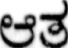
ಆತ
